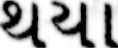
થયા
